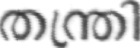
തന്ത്രി
